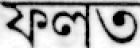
ফলত
